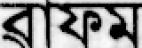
ৱাফম
